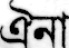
ঐনা
